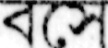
বসে
